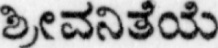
ಶ್ರೀವನಿತೆಯೆ
